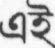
এই
